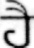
ਹੈ
